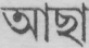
আছা
